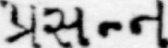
પ્રસન્ન
